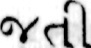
જતી
